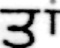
ਤਾਂ
